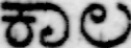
ಕಾಲ
